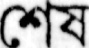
শেষ
